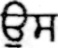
ਉਸ
